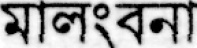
মালংবনা
